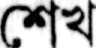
শেখ
